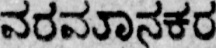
ವರಮಾನಕರ
